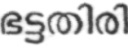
ഭട്ടതിരി
